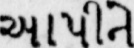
આપીને
